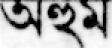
অহুম
